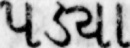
પડ્યા
